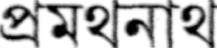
প্রমথনাথ
